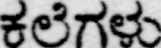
ಕಲೆಗಳು
